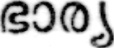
ഭാര്യ
